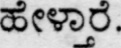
ಹೇಳ್ತಾರೆ.
